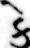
કે
